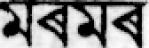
মৰমৰ
